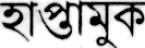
হাপ্তামুক
